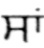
ਸਾਂ
